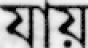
যায়
